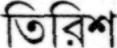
তিরিশ
